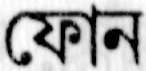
ফোন
